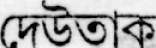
দেউতাক
